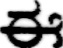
ಈ
